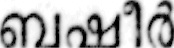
ബഷീര്‍
